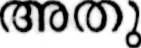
അതു
